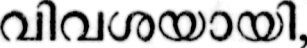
വിവശയായി,
